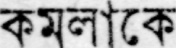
কমলাকে
